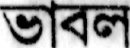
ভাবল
